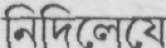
নিদিলেযে
